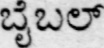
ಬೈಬಲ್
